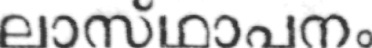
ലാസ്ഥാപനം
